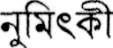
নুমিৎকী
